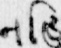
નહિ
